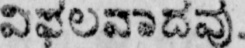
ವಿಫಲವಾದವು.
